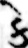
કે
